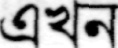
এখন
